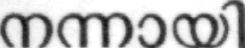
നന്നായി
